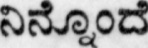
ನಿನ್ನೊಂದೆ
